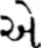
એ
